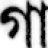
গা
